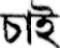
চাই
